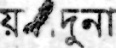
য়ান্নদুনা
